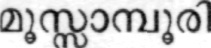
മൂസ്സാമ്പൂരി
